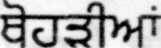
ਥੋਹੜੀਆਂ
